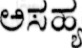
ಅಸಹ್ಯ
